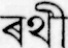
ৰথী
